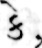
કે,
